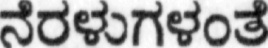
ನೆರಳುಗಳಂತೆ
